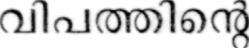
വിപത്തിന്റെ
